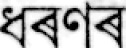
ধৰণৰ
